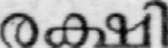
രക്ഷി
